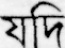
যদি
